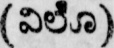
(ವಿಲೊ)
